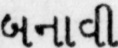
બનાવી
